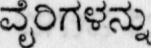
ವೈರಿಗಳನ್ನು
